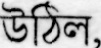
উঠিল,
